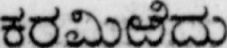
ಕರಮಿಱದು
